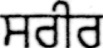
ਸਰੀਰ
